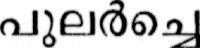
പുലര്‍ച്ചെ
